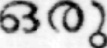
ഒരു
